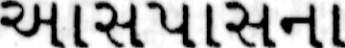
આસપાસના
